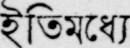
ইতিমধ্যে
